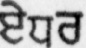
ਏਧਰ
